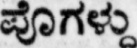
ಪೊಗಳ್ದು
